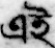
এই
